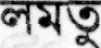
লমতু
